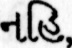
નહિ,
